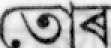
তোৰ
